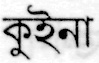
কুইনা
